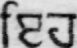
ਇਹ
